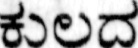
ಕುಲದ
